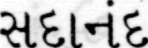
સદાનંદ
